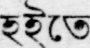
হইতে
